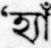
‘হ্যাঁ
